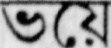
ভয়ে
